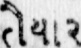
તૈયાર
